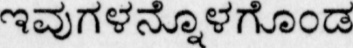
ಇವುಗಳನ್ನೊಳಗೊಂಡ
